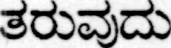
ತರುವುದು
